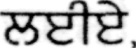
ਲਈਏ,
